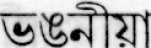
ভঙনীয়া
